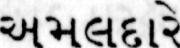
અમલદારે
